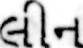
લીન
